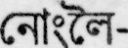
নোংলৈ-
